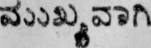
ಮುಖ್ಯವಾಗಿ
